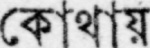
কোথায়
